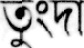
তুংদা
